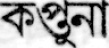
কপ্তুনা
